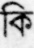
কি
